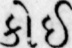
કોઈ
